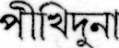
পীখিদুনা
